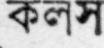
কলস
